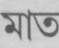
মাত
